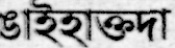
ঙাইহাক্তদা
